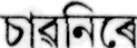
চাৱনিৰে
